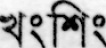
খংশিং
